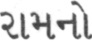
રામનો
